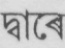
দ্বাৰে
